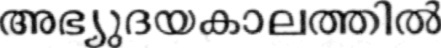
അഭ്യുദയകാലത്തില്‍
